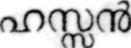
ഹസ്സന്‍
